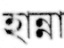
হান্না
